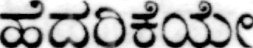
ಹೆದರಿಕೆಯೇ
